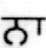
ਨਾ
